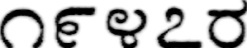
೧೯೪೭ರ
